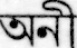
অনী
